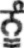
ਨੂੰ
